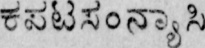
ಕಪಟಸಂನ್ಯಾಸಿ
